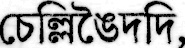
চেল্লিঙৈদদি,
